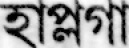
হাপ্লগা
